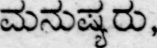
ಮನುಷ್ಯರು,
